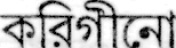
করিগীনো
